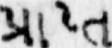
પ્રાપ્ત
